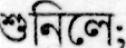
শুনিলে;
